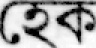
হেক
